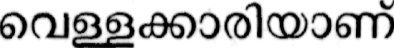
വെള്ളക്കാരിയാണ്
